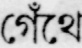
গেঁথে
